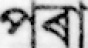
পৰা
